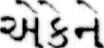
એકેને
